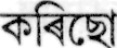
কৰিছো
